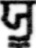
ਯੂ
